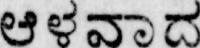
ಆಳವಾದ
